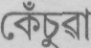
কেঁচুৱা
